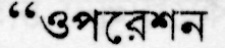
“ওপরেশন
